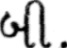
બી.
